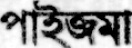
পাইজমা
